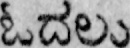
ಓದಲು
